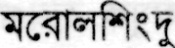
মরোলশিংদু
